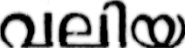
വലിയ
